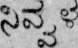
ನಿವ್ವಳ
